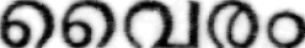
വൈരം
